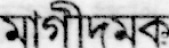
মাগীদমক
